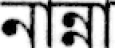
নান্না
